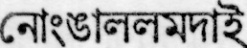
নোংঙাললমদাই
